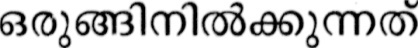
ഒരുങ്ങിനില്‍ക്കുന്നത്
